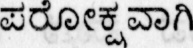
ಪರೋಕ್ಷವಾಗಿ
